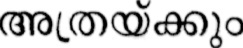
അത്രയ്ക്കും
